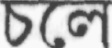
চলে
